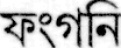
ফংগনি
